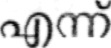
എന്ന്
